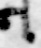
ન
